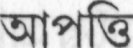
আপত্তি
